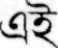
এই
